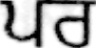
ਪਰ
